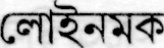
লোইনমক
